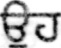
ਉਹ
